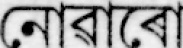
নোৱাৰো
